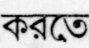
করতে
